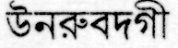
উনরুবদগী
